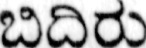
ಬಿದಿರು
